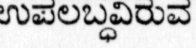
ಉಪಲಬ್ಧವಿರುವ
